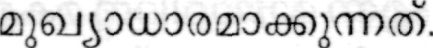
മുഖ്യാധാരമാക്കുന്നത്.
